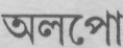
অলপো
